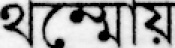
থম্মোয়
